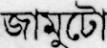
জামুটো
